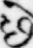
છે
